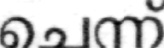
ചെന്ന്
